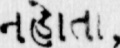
નહોતા,
